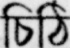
চিঠি
